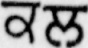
ਕਲ
